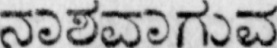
ನಾಶವಾಗುವ
